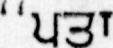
''ਪਤਾ
